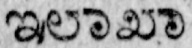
ಇಲಾಖಾ
